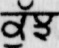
ਕੁੱਝ
